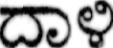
ದಾಳಿ
